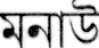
মনাউ
